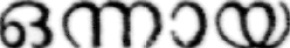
ഒന്നായ
